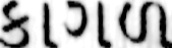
કાગળ
